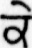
ਕੇ
